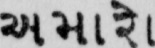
અમારો
